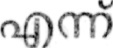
എന്ന്
